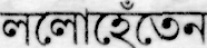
ললোহেঁতেন
